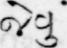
જેવું
